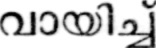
വായിച്ച്
